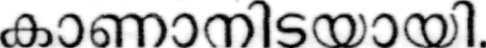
കാണാനിടയായി.
